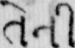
તેની
